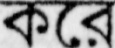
করে
